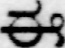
ಈ
